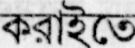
করাইতে
